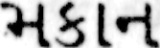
મકાન
